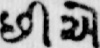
છીએ
